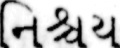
નિશ્ચય
